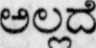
ಅಲ್ಲದೆ
